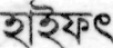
হাইফৎ
